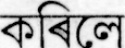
কৰিলে
